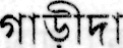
গাড়ীদা
